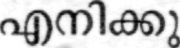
എനിക്കു
